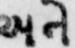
અને
